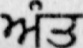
ਅੰਤ
